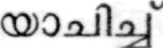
യാചിച്ച്
